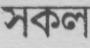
সকল
